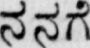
ನನಗೆ
